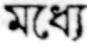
মধ্যে
